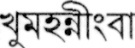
খুমহন্নীংবা
